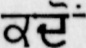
ਕਦੋਂ
